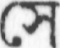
সে
